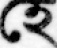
হে
